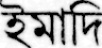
ইমাদি
